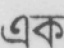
এক
